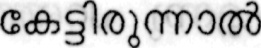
കേട്ടിരുന്നാല്‍
